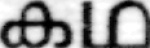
കഥ
